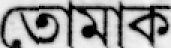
তোমাক
